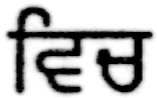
ਵਿਚ
